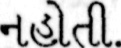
નહોતી.
